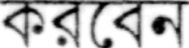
করবেন
